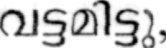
വട്ടമിട്ടു,
